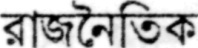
রাজনৈতিক
